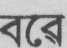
বৱে
